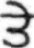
ਤੇ
